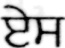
ਏਸ
